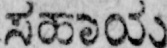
ಸಹಾಯ
